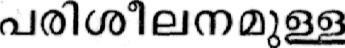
പരിശീലനമുള്ള
